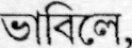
ভাবিলে,
